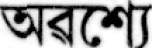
অৱশ্যে
